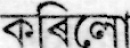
কৰিলো
